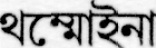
থম্মোইনা
